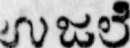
ಉಜಲೆ
